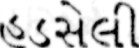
હડસેલી
